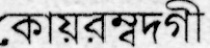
কোয়রম্বদগী
